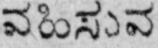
ವಹಿಸುವ
